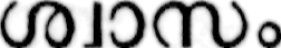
ശ്വാസം
